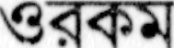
ওরকম
